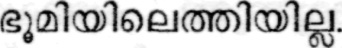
ഭൂമിയിലെത്തിയില്ല.
